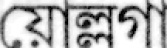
য়োল্লগা
